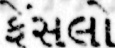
ફેંસલો
